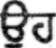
ਉਹ
